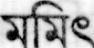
মমিৎ
